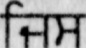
ਜਿਸ
